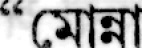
“মোন্না
